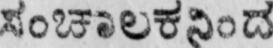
ಸಂಚಾಲಕನಿಂದ
